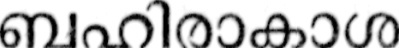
ബഹിരാകാശ
